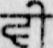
ਵੀ
